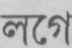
লগে
